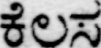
ಕೆಲಸ
